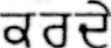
ਕਰਦੇ
